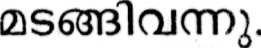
മടങ്ങിവന്നു.
